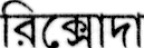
রিক্সোদা
